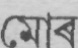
মোৰ
